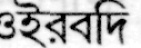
ওইরবদি
